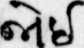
જોઈ
